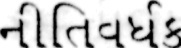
નીતિવર્ધક
